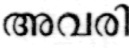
അവരി
